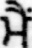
ਮੈਂ
